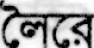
লৈরে
